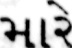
મારે
